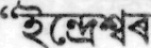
"ইন্দ্ৰেশ্বৰ
